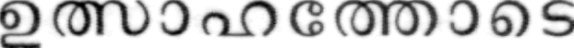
ഉത്സാഹത്തോടെ
